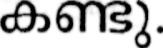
കണ്ടു.
